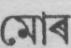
মোৰ
